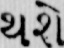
થશે
